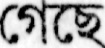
গেছে
